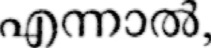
എന്നാല്‍,
